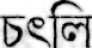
চৎলি
